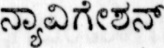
ನ್ಯಾವಿಗೇಶನ್
